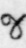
જ
